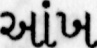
આંખ
